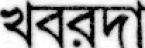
খবরদা
